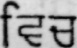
ਵਿਚ
